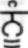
ਨੂੰ
